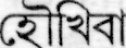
হৌখিবা
